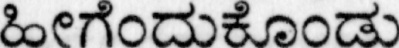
ಹೀಗೆಂದುಕೊಂಡು
